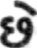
છે
